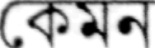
কেমন
